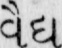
વૈધ
